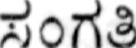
ಸಂಗತಿ
